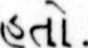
હતો.
